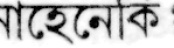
নাহেনেকি
